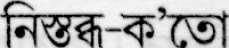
নিস্তব্ধ-ক'তো
